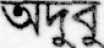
অদুবু
